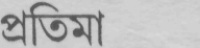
প্ৰতিমা
